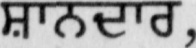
ਸ਼ਾਨਦਾਰ,
